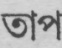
তাপ
